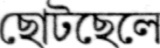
ছোটছেলে
